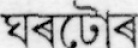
ঘৰটোৰ
